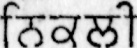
ਨਿਕਲੀ
